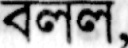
বলল,
